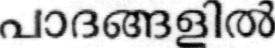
പാദങ്ങളില്‍
